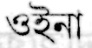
ওইনা
